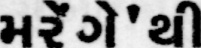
મરેંગે'થી
